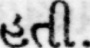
હતી.
